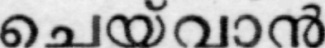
ചെയ്വാന്‍
